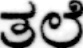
ತಲೆ
